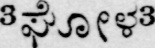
3ಘೋಳ3
